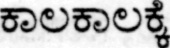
ಕಾಲಕಾಲಕ್ಕೆ
